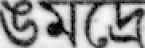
ঙমদ্রে
